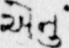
એનું
